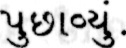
પુછાવ્યું.
